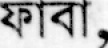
ফাবা,
